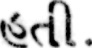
હતી.
